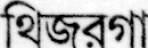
থিজরগা
